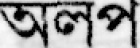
অলপ
